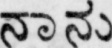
ನಾನು
